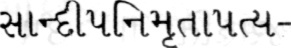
સાન્દીપનિમૃતાપત્ય-
